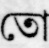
তো
